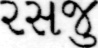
રસજુ
